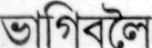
ভাগিবলৈ
